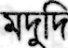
মদুদি
